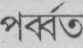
পৰ্ব্বত
